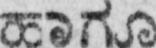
ಹಾಗೂ
